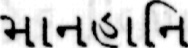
માનહાનિ
